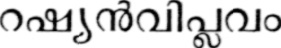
റഷ്യന്‍വിപ്ലവം
